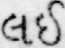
લઈ
